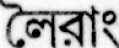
লৈরাং
